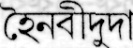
হৈনবীদুদা
